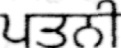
ਪਤਨੀ
